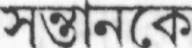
সন্তানকে
